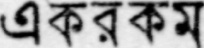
একরকম
